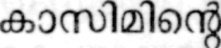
കാസിമിന്റെ
